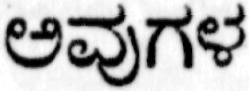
ಅವುಗಳ
